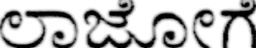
ಲಾಜೋಗೆ
